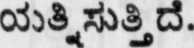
ಯತ್ನಿಸುತ್ತಿದೆ.
